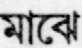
মাঝে
